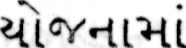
યોજનામાં
